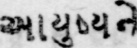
આયુષ્યને
